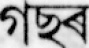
গছৰ
